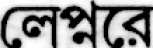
লেপ্নরে
